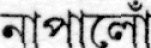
নাপালোঁ
